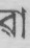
ৱা
